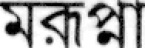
মরূপ্না
